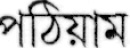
পঠিয়াম
